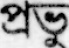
প্রভু
